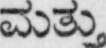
ಮತ್ತು
